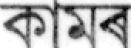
কামৰ
